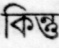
কিন্তু
